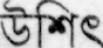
উশিৎ
